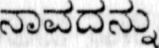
ನಾವದನ್ನು
